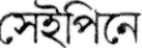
সেইপিনে
